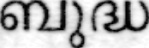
ബുദ്ധ
